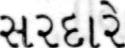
સરદારે
